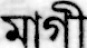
মাগী
